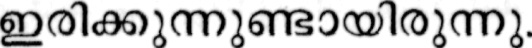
ഇരിക്കുന്നുണ്ടായിരുന്നു.
